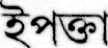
ইপক্তা
